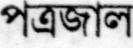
পত্রজাল
